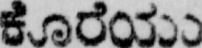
ಕೊರೆಯು
